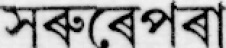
সৰুৰেপৰা
